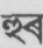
হুৰ
